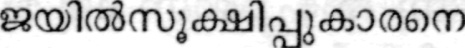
ജയില്‍സൂക്ഷിപ്പുകാരനെ
